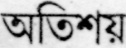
অতিশয়
